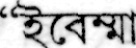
“ইবেম্মা
